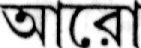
আরো
